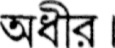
অধীর।
